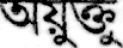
অয়ুক্তু
